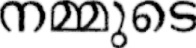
നമ്മുടെ
